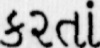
કરતાં
